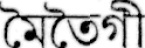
মৈতৈগী
